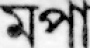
মপা
